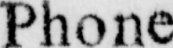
Phone
